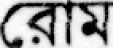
রোম
